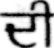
ਦੀ
